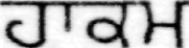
ਹਾਕਮ
